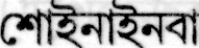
শোইনাইনবা
